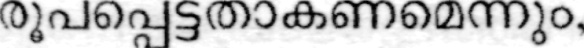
രൂപപ്പെട്ടതാകണമെന്നും,
